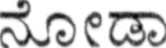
ನೋಡಾ
